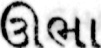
ઊભા
